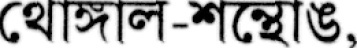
থোঙ্গাল-শন্থোঙ,
